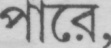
পারে,
